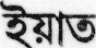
ইয়াত
